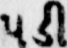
પડી
